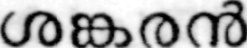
ശങ്കരന്‍
